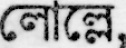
লোল্লে,
